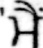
'ਮੈਂ
